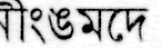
নীংঙমদে
